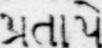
પ્રતાપે
